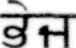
ਭੇਜ
